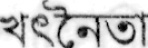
খৎনৈতা
